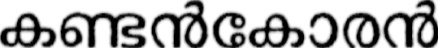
കണ്ടന്‍കോരന്‍
